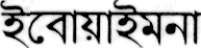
ইবোয়াইমনা
